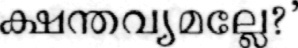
ക്ഷന്തവ്യമല്ലേ?’
